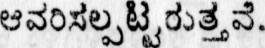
ಆವರಿಸಲ್ಪಟ್ಟಿರುತ್ತವೆ.
